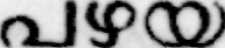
പഴയ
